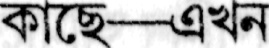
কাছে–এখন
